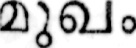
മുഖം
